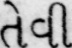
તેવી
